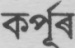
কৰ্পূৰ
